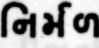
નિર્મળ
